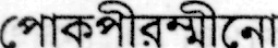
পোকপীরম্মীনো
